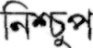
নিশ্চুপ
